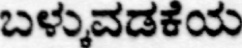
ಬಳ್ಕುವಡಕೆಯ
